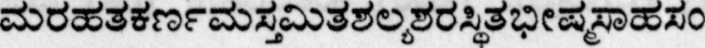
ಮರಹತಕರ್ಣಮಸ್ತಮಿತಶಲ್ಯಶರಸ್ಥಿತಭೀಷ್ಮಸಾಹಸಂ
